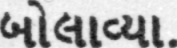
બોલાવ્યા.
